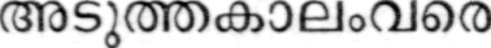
അടുത്തകാലംവരെ
